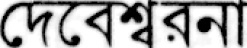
দেবেশ্বরনা
